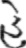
હે
